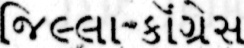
જિલ્લા-કૉંગ્રેસ
